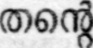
തന്റെ
